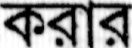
করার
